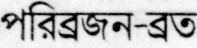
পরিব্রজন-ব্রত
